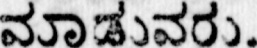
ಮಾಡುವರು.
